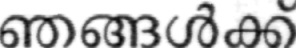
ഞങ്ങള്‍ക്ക്
